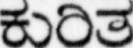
ಕುರಿತ
